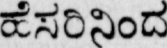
ಹೆಸರಿನಿಂದ
